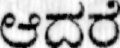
ಆದರೆ
